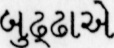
બુઢ્ઢાએ
